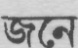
জনে
